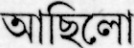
আছিলো
